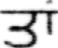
ਤਾਂ
